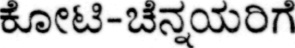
ಕೋಟಿ-ಚೆನ್ನಯರಿಗೆ
